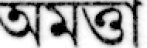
অমত্তা
